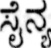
ಸೈನ್ಯ
